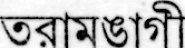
তরামঙাগী
